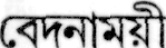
বেদনাময়ী
